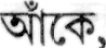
আঁকে,
